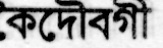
কৈদৌবগী
